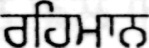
ਰਹਿਮਾਨ
